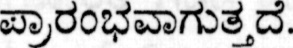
ಪ್ರಾರಂಭವಾಗುತ್ತದೆ.
